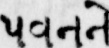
પવનને
